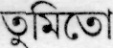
তুমিতো
